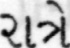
રાત્રે
